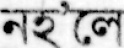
নহ'লে
